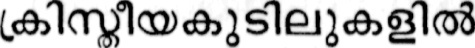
ക്രിസ്തീയകുടിലുകളില്‍
